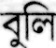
বুলি
